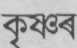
কৃষ্ণৰ
